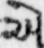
એ
